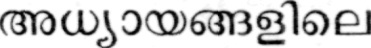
അധ്യായങ്ങളിലെ
